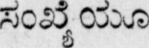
ಸಂಖ್ಯೆಯೂ
